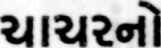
ચાચરનો
